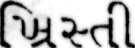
ખ્રિસ્તી
